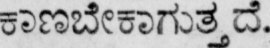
ಕಾಣಬೇಕಾಗುತ್ತದೆ.
